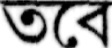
তবে
